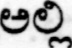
ಅಲ್ಲಿ
